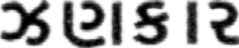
ઝણકાર
